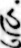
હું
